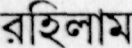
রহিলাম
